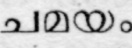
ചമയം
